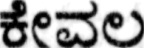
ಕೇವಲ
